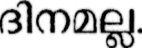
ദിനമല്ല.
